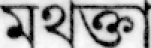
মথক্তা
